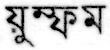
য়ুম্ফম
